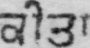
ਕੀਤਾ
